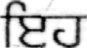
ਇਹ
